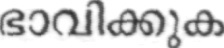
ഭാവിക്കുക
